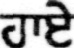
ਹਾਏ
